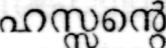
ഹസ്സന്റെ
